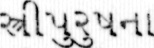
સ્ત્રીપુરૂષના
